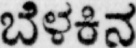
ಬೆಳಕಿನ
